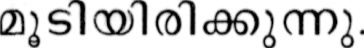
മൂടിയിരിക്കുന്നു.
